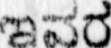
ಇವರ
